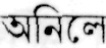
অনিলে
